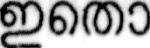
ഇതൊ
